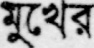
মুখের
